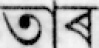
তাৰ
